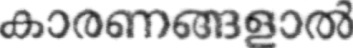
കാരണങ്ങളാല്‍
